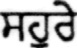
ਸਹੁਰੇ
